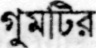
গুমটির
